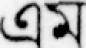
এম
